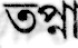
তপ্না
